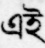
এই
